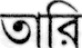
তারি
